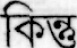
কিন্তু
